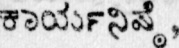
ಕಾರ್ಯನಿಷ್ಠೆ,
